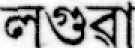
লগুৱা
